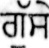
ਗੁੱਸੇ
